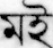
মই
